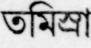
তমিস্রা
